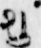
શું
